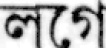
লগে
